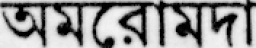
অমরোমদা
